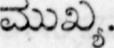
ಮುಖ್ಯ.
